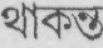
থাকন্ত
